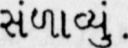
સંળાવ્યું.
